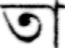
তা
